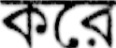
করে
